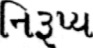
નિરૂપ્ય
